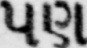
પણ
